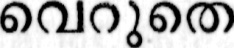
വെറുതെ
